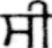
ਸੀ
